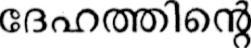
ദേഹത്തിന്റെ
